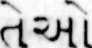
તેઓ
